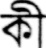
কী
